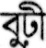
বুঢ়ী
